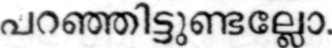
പറഞ്ഞിട്ടുണ്ടല്ലോ.
